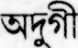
অদুগী
